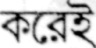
করেই
